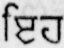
ਇਹ
